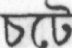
চটে
